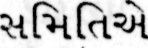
સમિતિએ
